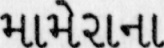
મામેરાના
